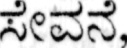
ಸೇವನೆ,
